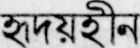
হৃদয়হীন
